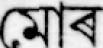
মোৰ
